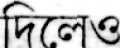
দিলেও
